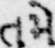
તમે
